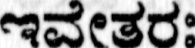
ಇವೇತರಃ
